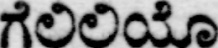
ಗೆಲಿಲಿಯೊ
